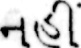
નહીં
